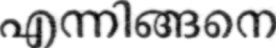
എന്നിങ്ങനെ
